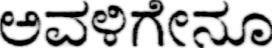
ಅವಳಿಗೇನೂ
